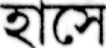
হাসে
